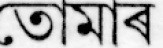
তোমাৰ
